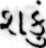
શકું
